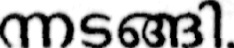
ന്നടങ്ങി.
